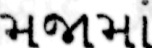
મજામાં
